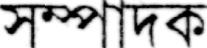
সম্পাদক
